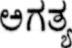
ಅಗತ್ಯ
